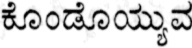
ಕೊಂಡೊಯ್ಯುವ
